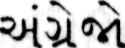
અંગ્રેજો
